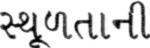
સ્થૂળતાની
